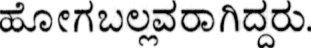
ಹೋಗಬಲ್ಲವರಾಗಿದ್ದರು.
